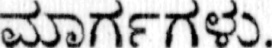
ಮಾರ್ಗಗಳು.
